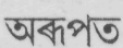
অৰূপত
